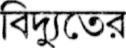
বিদ্যুতের
